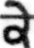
ਕੇ
